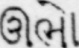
ઊભો
